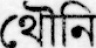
থৌনি
